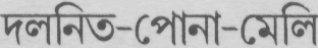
দলনিত-পোনা-মেলি
